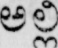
ಅಲ್ಲಿ
